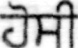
ਹੋਸੀ
